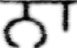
ਨਾ
